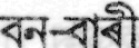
বন-বাৰী
